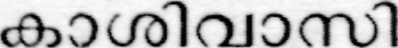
കാശിവാസി
